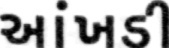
આંખડી
